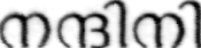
നന്ദിനി
